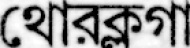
থোরক্লগা
